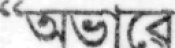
"অভাৱে
